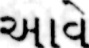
આવે
